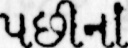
પછીના
